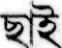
ছাই
